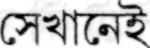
সেখানেই
